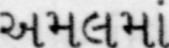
અમલમાં
